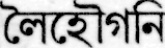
লৈহৌগনি
